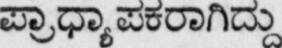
ಪ್ರಾಧ್ಯಾಪಕರಾಗಿದ್ದು
